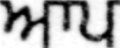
ਆਪ
